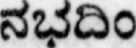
ನಭದಿಂ
